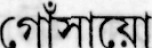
গোঁসায়ো
